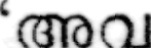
‘അവ
